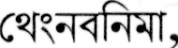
থেংনবনিমা,
